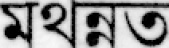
মথন্নত
